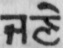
ਜਣੇ
